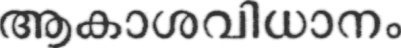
ആകാശവിധാനം
